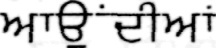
ਆਉਂਦੀਆਂ
